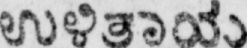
ಉಳಿತಾಯ
